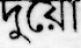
দুয়ো
